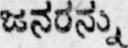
ಜನರನ್ನು
